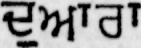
ਦੁਆਰਾ
